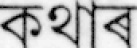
কথাৰ
